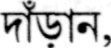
দাঁড়ান,
